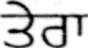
ਤੇਰਾ
